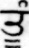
ਤੂੰ
